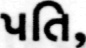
પતિ,
